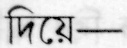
দিয়ে-
